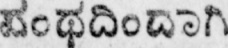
ಪಂಥದಿಂದಾಗಿ
